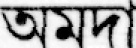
অমদা
